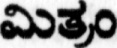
ಮಿತ್ರ೦
